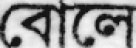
বোলে
